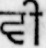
ਵੀ
